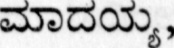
ಮಾದಯ್ಯ,
